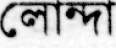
লোন্দা
